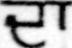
ਦਾ
